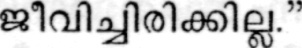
ജീവിച്ചിരിക്കില്ല.”
